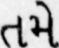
તમે
